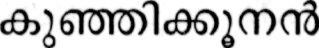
കുഞ്ഞിക്കൂനന്‍
